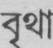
বৃথা
